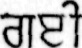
ਗਈ
